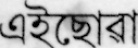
এইছোৱা
